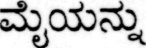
ಮೈಯನ್ನು
